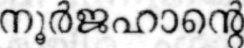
നൂര്‍ജഹാന്റെ
